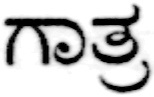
ಗಾತ್ರ
